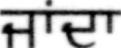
ਜਾਂਦਾ
